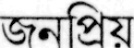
জনপ্রিয়
